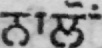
ਨਾਲੋਂ
